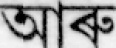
আৰু
